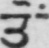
ਤੋਂ
